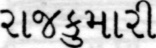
રાજકુમારી
